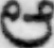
ಆ
